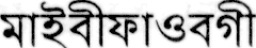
মাইবীফাওবগী
